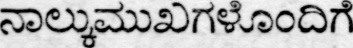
ನಾಲ್ಕುಮುಖಗಳೊಂದಿಗೆ
